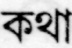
কথা
